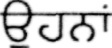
ਉਹਨਾਂ
